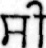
ਸੀ
